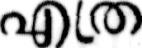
എത്ര
